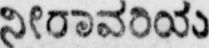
ನೀರಾವರಿಯ
